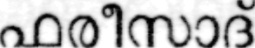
ഫരീസാദ്
